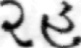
રહ
